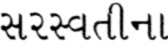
સરસ્વતીના
